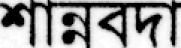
শান্নবদা
